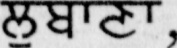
ਲੁਬਾਣਾ,
